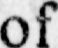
of
